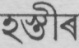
হস্তীৰ
